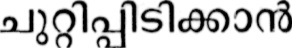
ചുറ്റിപ്പിടിക്കാന്‍
